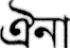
ঐনা
